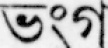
ভংগ
